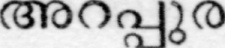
അറപ്പുര
